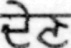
ਦੇਣ
